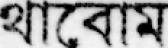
থাবোম
